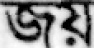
জয়
